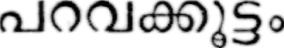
പറവക്കൂട്ടം
